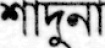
শাদুনা
